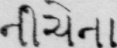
નીચેના
